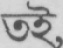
তই,
